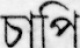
চাপি
